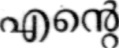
എന്റെ
